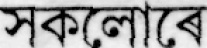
সকলোৰে
